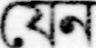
যেন
